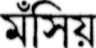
মঁসিয়
